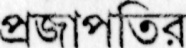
প্রজাপতির
